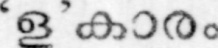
’ള’കാരം
